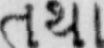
તથા
